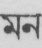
মন
